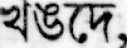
খঙদে,
